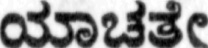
ಯಾಚತೇ
